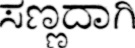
ಸಣ್ಣದಾಗಿ
